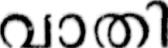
വാതി
